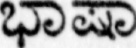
ಭಾಷಾ
